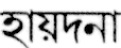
হায়দনা
